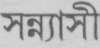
সন্ন্যাসী
